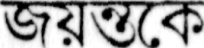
জয়ন্তকে
